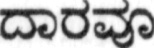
ದಾರವೂ
